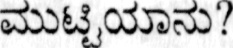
ಮುಟ್ಟಿಯಾನು?
